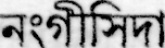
নংগীসিদা
